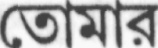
তোমার
